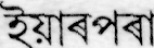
ইয়াৰপৰা
